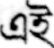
এই
